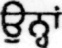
ਉਨ੍ਹਾਂ
